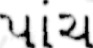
પાંચ
